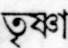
তৃষ্ণা
